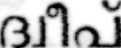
ദ്വീപ്
